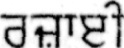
ਰਜ਼ਾਈ
